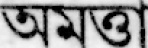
অমত্তা
